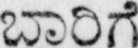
ಬಾರಿಗೆ
